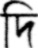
দি
